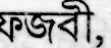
ফজবী,
